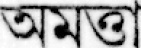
অমত্তা
